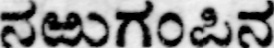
ನಱುಗಂಪಿನ
